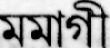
মমাগী
